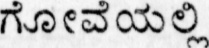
ಗೋವೆಯಲ್ಲಿ
